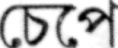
চেপে
